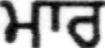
ਮਾਰ
